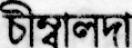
চীম্বালদা
